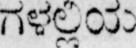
ಗಳಲ್ಲಿಯ
